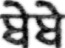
ਬੇਬੇ
